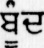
ਬੂੰਦ
